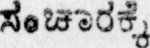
ಸಂಚಾರಕ್ಕೆ
